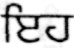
ਇਹ
